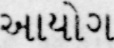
આયોગ
